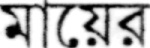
মায়ের
